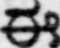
ಈ
